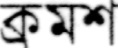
ক্রমশ
